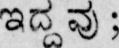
ಇದ್ದವು;
